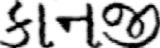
કાનજી
